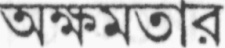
অক্ষমতার
